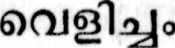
വെളിച്ചം
